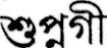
শুপ্নগী
